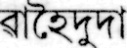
ৱাহৈদুদা
